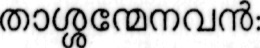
താശ്ശന്മേനവന്‍:
